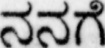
ನನಗೆ
